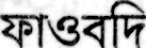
ফাওবদি
